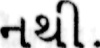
નથી.
